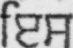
ਇਸ
